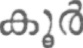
കൂര്‍
